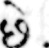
છે.
